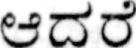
ಆದರೆ
